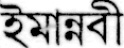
ইমান্নবী
